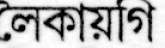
লৈকায়গি
